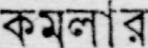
কমলার
